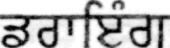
ਡਰਾਇੰਗ
